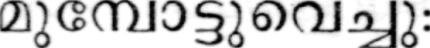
മുമ്പോട്ടുവെച്ചു:
